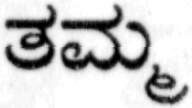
ತಮ್ಮ
